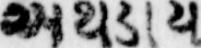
અથડાય
